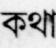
কথা
